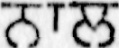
ਨਾਲ
